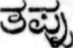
ತಪ್ಪು
